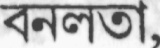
বনলতা,
